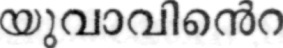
യുവാവിന്റെ
